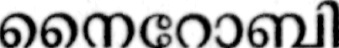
നൈറോബി
